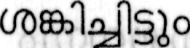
ശങ്കിച്ചിട്ടും
